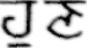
ਹੁਣ
